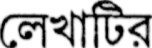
লেখাটির
